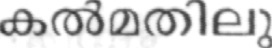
കല്‍മതിലു
